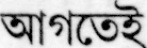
আগতেই
